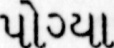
પોગ્યા
